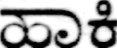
ಹಾಕಿ
